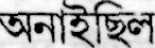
অনাইছিল
